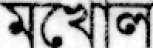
মখোল
